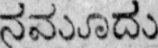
ನಮೂದು
